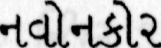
નવોનકોર
